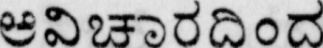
ಅವಿಚಾರದಿಂದ
